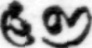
હજી
